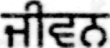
ਜੀਵਨ
